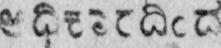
ಅಧಿಕಾರದಿಂದ
